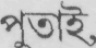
পুতাই,
